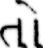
તો
